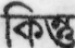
কিন্তু
